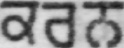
ਕਰਨ
